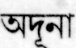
অদূনা
